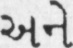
અને
